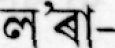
ল'ৰা-
